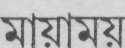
মায়াময়
